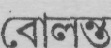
বোলন্ত
